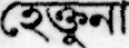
হেক্তুনা
